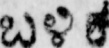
ಬಳಿಕ
